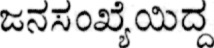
ಜನಸಂಖ್ಯೆಯಿದ್ದ
